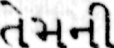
તેમની
